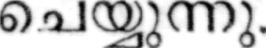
ചെയ്യുന്നു.
